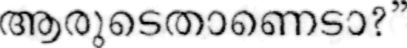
ആരുടെതാണെടാ?"
